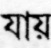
যায়
